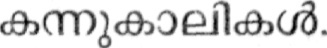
കന്നുകാലികള്‍.
